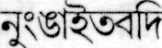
নুংঙাইতবদি
